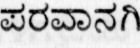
ಪರವಾನಗಿ
